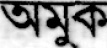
অমুক
